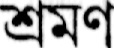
শ্রমণ
